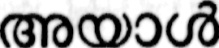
അയാള്‍
